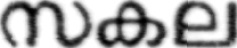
സകല
